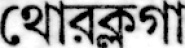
থোরক্লগা
